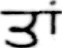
ਤਾਂ
